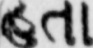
હતા
